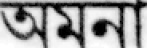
অমনা
